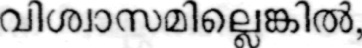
വിശ്വാസമില്ലെങ്കില്‍,
